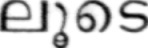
ലൂടെ
